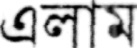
এলাম
